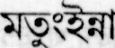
মতুংইন্না
